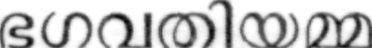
ഭഗവതിയമ്മ
